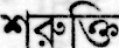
শরুক্তি
